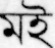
মই
